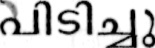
പിടിച്ചു
